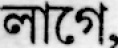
লাগে,
